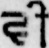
ਵੀ
